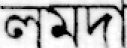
লমদা
